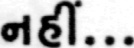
નહીં.........
